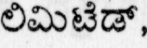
ಲಿಮಿಟೆಡ್,
